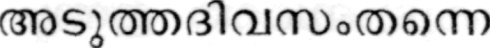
അടുത്തദിവസംതന്നെ
